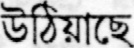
উঠিয়াছে
